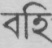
বহি
